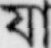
যা
